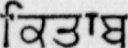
ਕਿਤਾਬ
